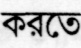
করতে
